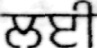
ਲਈ
